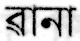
ৱানা
